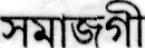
সমাজগী
